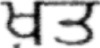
ਖ਼ਤ
